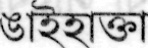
ঙাইহাক্তা
